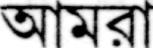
আমরা
